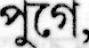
পুগে,
